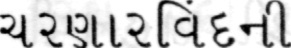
ચરણારવિંદની
